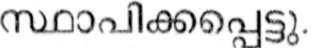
സ്ഥാപിക്കപ്പെട്ടു.
